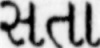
સતા
